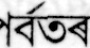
পর্বতৰ
